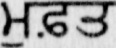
ਮੁਫ਼ਤ
